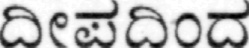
ದೀಪದಿಂದ
